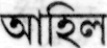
আহিল
